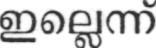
ഇല്ലെന്ന്
